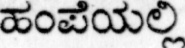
ಹಂಪೆಯಲ್ಲಿ
